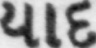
યાદ
